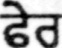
ਫੇਰ
